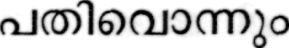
പതിവൊന്നും
